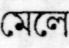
মেলে
